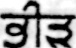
ਭੀੜ
